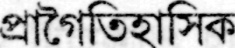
প্রাগৈতিহাসিক
